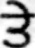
ਤੇ
